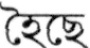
হৈছে
